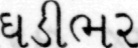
ઘડીભર
